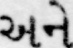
અને
